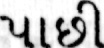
પાછી
